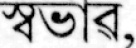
স্বভাৱ,
